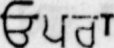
ਓਪਰਾ
